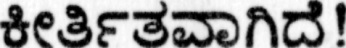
ಕೀರ್ತಿತವಾಗಿದೆ!
